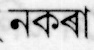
নকৰা
